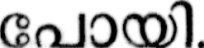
പോയി.
